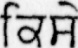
ਕਿਸੇ
